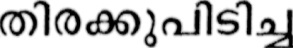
തിരക്കുപിടിച്ച
